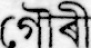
গৌৰী
